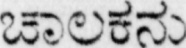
ಚಾಲಕನು
